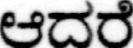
ಆದರೆ
